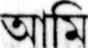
আমি
